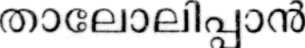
താലോലിപ്പാന്‍
